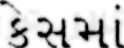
કેસમાં
